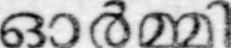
ഓര്‍മ്മി
